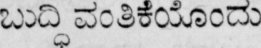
ಬುದ್ಧಿವಂತಿಕೆಯೊಂದು
